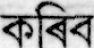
কৰিব
